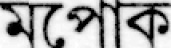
মপোক
